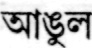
আঙুল
